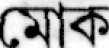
মোক
